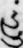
હું
